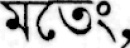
মতেং,
